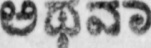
ಅಥವಾ
